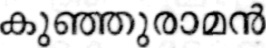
കുഞ്ഞുരാമന്‍
